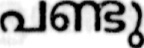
പണ്ടു
